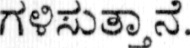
ಗಳಿಸುತ್ತಾನೆ.
